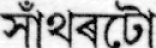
সাঁথৰটো
